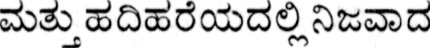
ಮತ್ತುಹದಿಹರೆಯದಲ್ಲಿನಿಜವಾದ
